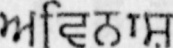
ਅਵਿਨਾਸ਼
